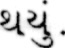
થયું.
